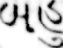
બહુ
